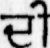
ਦੀ
